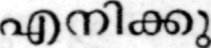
എനിക്കു
